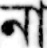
না
